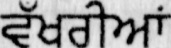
ਵੱਖਰੀਆਂ
